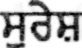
ਸੁਰੇਸ਼
